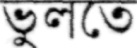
ভুলতে
